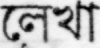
লেখা
